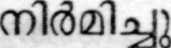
നിര്‍മിച്ചു
